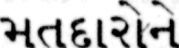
મતદારોને
